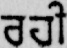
ਰਹੀ
